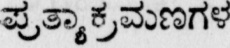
ಪ್ರತ್ಯಾಕ್ರಮಣಗಳ
